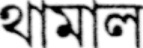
থামাল
